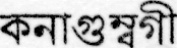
কনাগুম্বগী
